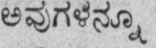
ಅವುಗಳನ್ನೂ
